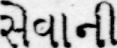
સેવાની
